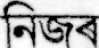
নিজৰ
